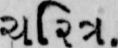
ચરિત્ર.
